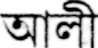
আলী
